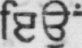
ਇਉਂ
